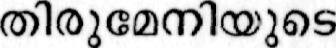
തിരുമേനിയുടെ
